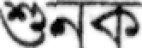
শুনক
